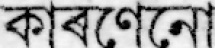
কাৰণেনো
